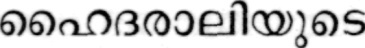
ഹൈദരാലിയുടെ
